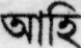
আহি
